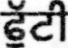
ਫੁੱਟੀ
